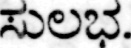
ಸುಲಭ.
